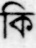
কি
